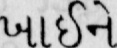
ખાઈને
